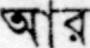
আর
